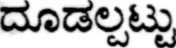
ದೂಡಲ್ಪಟ್ಟು
